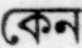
কেন
